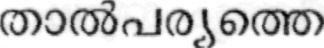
താല്‍പര്യത്തെ
